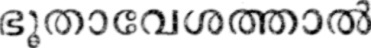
ഭൂതാവേശത്താല്‍
